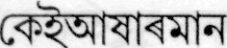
কেইআষাৰমান
